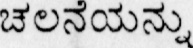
ಚಲನೆಯನ್ನು
